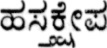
ಹಸ್ತಕ್ಷೇಪ
